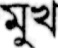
মুখ
